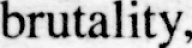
brutality,
